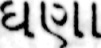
ઘણા
